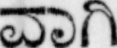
ವಾಗಿ
